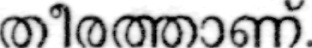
തീരത്താണ്.
